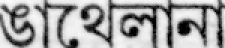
ঙাথেলানা
